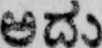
ಅದು
